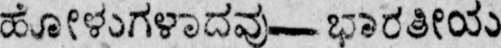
ಹೋಳುಗಳಾದವು-ಭಾರತೀಯ
